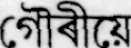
গৌৰীয়ে
